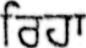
ਰਿਹਾ
